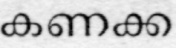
കണക്ക
